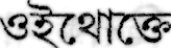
ওইথোক্তে
